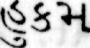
હુકમ
